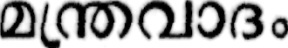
മന്ത്രവാദം
